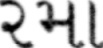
રમા
